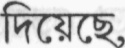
দিয়েছে,
